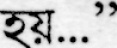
হয়..."
